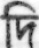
দি
